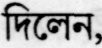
দিলেন,
